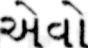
એવો
